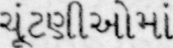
ચૂંટણીઓમાં
